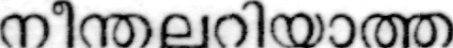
നീന്തലറിയാത്ത
